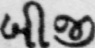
બીજી
